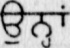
ਉਨ੍ਹਾਂ
